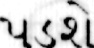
પડશે
